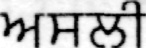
ਅਸਲੀ
